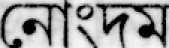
নোংদম
